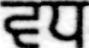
ਵਧ
